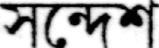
সন্দেশ
